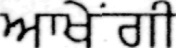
ਆਖੇਂਗੀ
